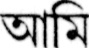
আমি
